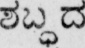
ಶಬ್ಧದ
